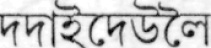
দদাইদেউলৈ
